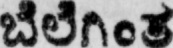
ಬೆಲೆಗಿಂತ
